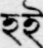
হই
